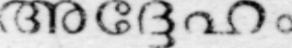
അദ്ദേഹം
